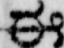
ಈ
